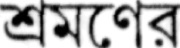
শ্রমণের
